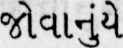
જોવાનુંયે
